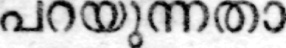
പറയുന്നതാ
